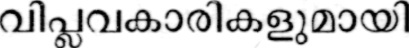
വിപ്ലവകാരികളുമായി
